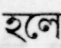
হলে
